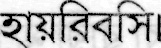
হায়রিবসি।
